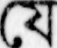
যে
